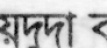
য়দুদা
